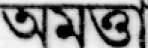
অমত্তা
